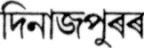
দিনাজপুৰৰ
